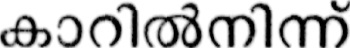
കാറില്‍നിന്ന്
